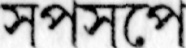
সপসপে
